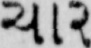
ચાર
